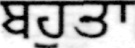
ਬਹੁਤਾ
